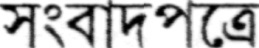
সংবাদপত্রে
